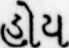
હોય
